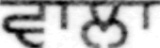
ਵਾਲਾ
